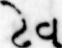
ટેવ
